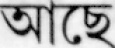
আছে
